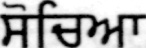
ਸੋਚਿਆ
